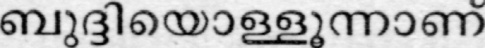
ബുദ്ദിയൊള്ളൂന്നാണ്
